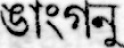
ঙাংগনু
